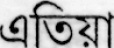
এতিয়া
